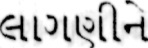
લાગણીને
